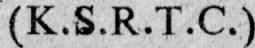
(K.S.R.T.C.)
